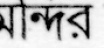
মন্দির
